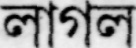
লাগল
